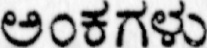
ಅಂಕಗಳು
